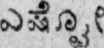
ಎಷ್ಟೋ
